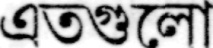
এতগুলো
